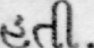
હતી.
